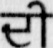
ਦੀ
